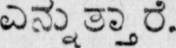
ಎನ್ನುತ್ತಾರೆ.
